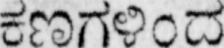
ಕಣಗಳಿಂದ
